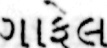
ગાફેલ
